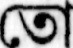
তো
